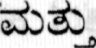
ಮತ್ತು
